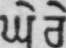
ਘੇਰੇ
